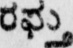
ರಫ್ತು
